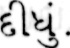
દીધું.
